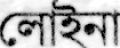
লোইনা
